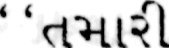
"તમારી
